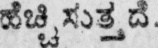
ಹೆಚ್ಚಿಸುತ್ತದೆ.
